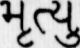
મૃત્યુ
